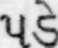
પડે
